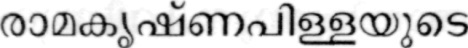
രാമകൃഷ്ണപിള്ളയുടെ
